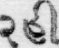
રહી
